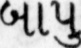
બાપુ
